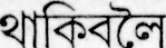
থাকিবলৈ
